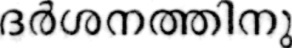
ദര്‍ശനത്തിനു
